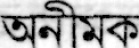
অনীমক
